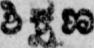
ಶಿಕ್ಷಣ
